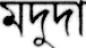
মদুদা
